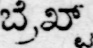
ಬ್ರೆಖ್ಟ್
